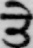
ਤੇ
